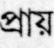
প্রায়
